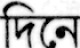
দিনে
